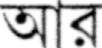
আর
